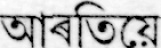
আৰতিয়ে
